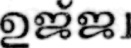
ഉജ്ജ്വ
